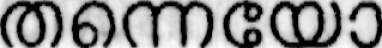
തന്നെയോ
